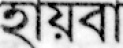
হায়বা
